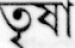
তৃষা
